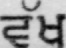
ਵੱਖ
